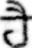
ਹੈ
